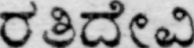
ರತಿದೇವಿ
